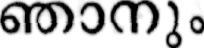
ഞാനും
